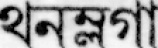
থনম্লগা
